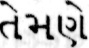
તેમણે
